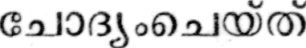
ചോദ്യംചെയ്ത്
